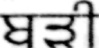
ਬੜੀ
